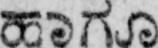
ಹಾಗೂ
